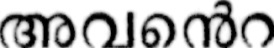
അവന്റെ
